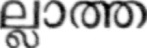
ല്ലാത്ത
